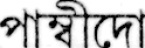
পাম্বীদো
